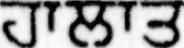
ਹਾਲਾਤ
